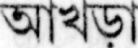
আখড়া
